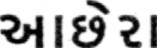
આછેરા
